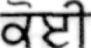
ਕੋਈ
